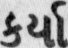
કર્યા
